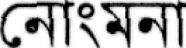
নোংমনা
